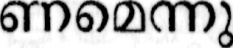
ണമെന്നു
